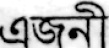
এজনী
